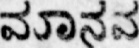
ಮಾನವ
